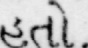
હતો.
